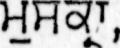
ਮੁਸਕ੍ਰਾ,
